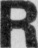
R
